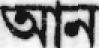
আন
